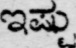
ಇಷ್ಟು
